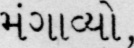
મંગાવ્યો,
